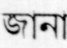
জানা
